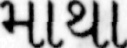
માથા
